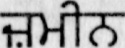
ਜ਼ਮੀਨ
